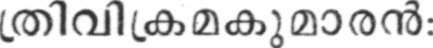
ത്രിവിക്രമകുമാരന്‍:
